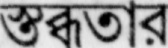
স্তব্ধতার
